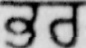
ਭਰ
